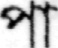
পা
